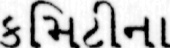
કમિટીના
